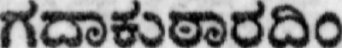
ಗದಾಕುಠಾರದಿಂ
